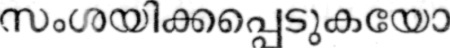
സംശയിക്കപ്പെടുകയോ
